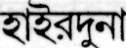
হাইরদুনা
